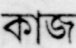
কাজ
